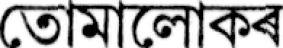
তোমালোকৰ
